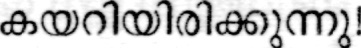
കയറിയിരിക്കുന്നു!
